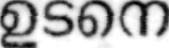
ഉടനെ
